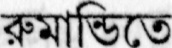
রুমান্ডিতে
